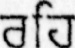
ਰਹਿ
